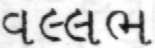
વલ્લભ
